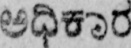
ಅಧಿಕಾರ
